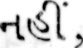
નહીં,
